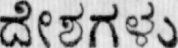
ದೇಶಗಳು
